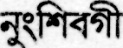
নুংশিবগী
